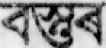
বস্তুৰ
